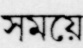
সময়ে
